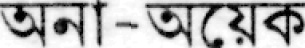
অনা-অয়েক
